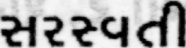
સરસ્વતી
